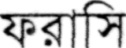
ফরাসি
